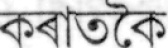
কৰাতকৈ
